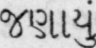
જણાયું
